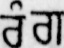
ਰੰਗ
